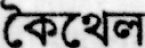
কৈথেল
